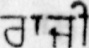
ਰਾਜੀ
